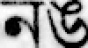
নঙ
